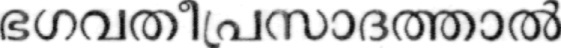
ഭഗവതീപ്രസാദത്താല്‍
